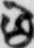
છે
